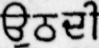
ਉਠਦੀ
